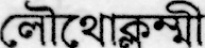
লৌথোক্লম্মী
